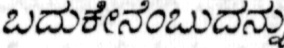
ಬದುಕೇನೆಂಬುದನ್ನು
